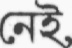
নেই,
